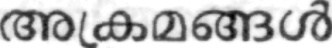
അക്രമങ്ങള്‍
